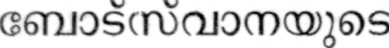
ബോട്സ്വാനയുടെ
